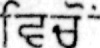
ਵਿਚੋਂ
